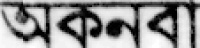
অকনবা
